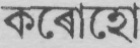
কৰোহো
